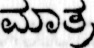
ಮಾತ್ರ
